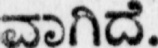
ವಾಗಿದೆ.
